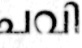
ചവി
